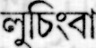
লুচিংবা
